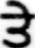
ਤੇ
